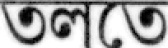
তলতে
